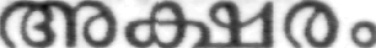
അക്ഷരം
